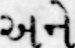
અને
